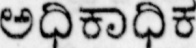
ಅಧಿಕಾಧಿಕ
